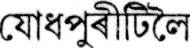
যোধপুৰীটিলৈ
